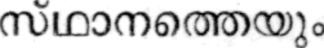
സ്ഥാനത്തെയും
